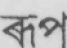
ৰূপ
